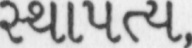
સ્થાપત્ય,
